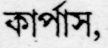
কার্পাস,
